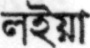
লইয়া
